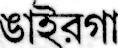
ঙাইরগা
